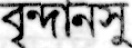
বৃন্দানসু
